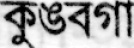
কুঙবগা
